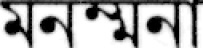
মনম্মনা
